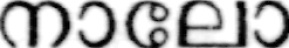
നാലോ
